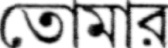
তোমার
